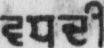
ਵਧਦੀ
